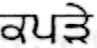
ਕਪੜੇ
